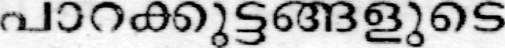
പാറക്കൂട്ടങ്ങളുടെ
